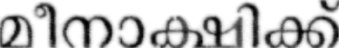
മീനാക്ഷിക്ക്
